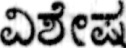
ವಿಶೇಷ
